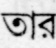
তার
